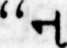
"ન
